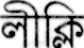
লীক্লি
